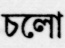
চলো
